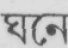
ঘনে
